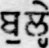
ਬੁਲ੍ਹੇ
